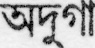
অদুগা
